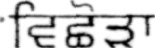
ਵਿਛੋੜਾ
